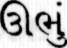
ઊભું
